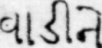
વાડીને
